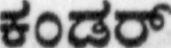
ಕಂಡರ್
